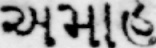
અમાહ
